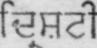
ਦ੍ਰਿਸ਼ਟੀ
